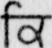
ਕਿ
